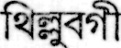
থিল্লুবগী
